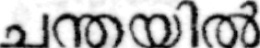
ചന്തയില്‍
